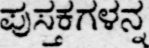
ಪುಸ್ತಕಗಳನ್ನ
